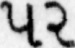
પર
